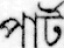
পাৰ্ট
